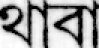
থাবা
